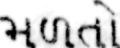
મળતો
